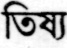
তিষ্য
